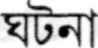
ঘটনা
